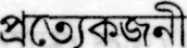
প্ৰত্যেকজনী
